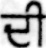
ਦੀ
